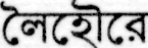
লৈহৌরে
